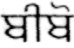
ਬੀਬੋ
